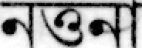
নত্তনা
